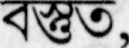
বস্তুত,
